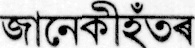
জানেকীহঁতৰ
